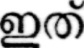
ഇത്
